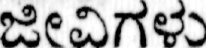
ಜೀವಿಗಳು
